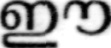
ഈ
